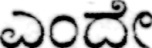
ಎಂದೇ
